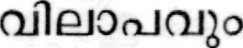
വിലാപവും
